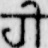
ਹੀ
